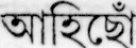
আহিছোঁ
